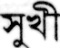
সুখী
